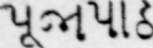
પૂજાપાઠ
